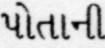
પોતાની
